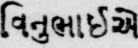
વિનુભાઈએ
